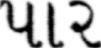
પાર
